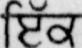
ਇੱਕ
